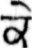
ਕੇ
